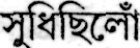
সুধিছিলোঁ
